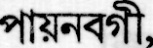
পায়নবগী,
